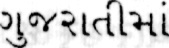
ગુજરાતીમાં
